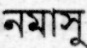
নমাসু
